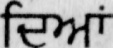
ਦਿਆਂ
